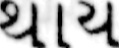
થાય
